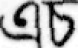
এচ
